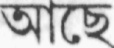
আছে
